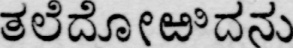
ತಲೆದೋಱಿದನು
